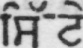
ਸਿੱਟੇ
